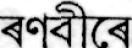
ৰণবীৰে
